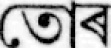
তোৰ
